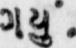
ગયું.
